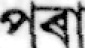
পৰা
